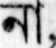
না,
